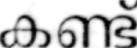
കണ്ട്
